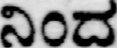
ನಿಂದ
